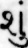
શું
